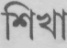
শিখা
